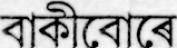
বাকীবোৰে
